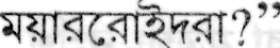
ময়াররোইদরা?”
